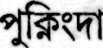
পুক্নিংদা
